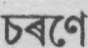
চৰণে
